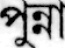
পুন্না
